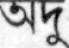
অদু
